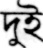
দুই
